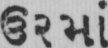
ઉરમાં
